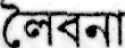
লৈবনা
